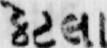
કેટલા
